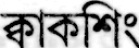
ক্বাকশিং
